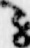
કે
